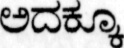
ಅದಕ್ಕೂ
